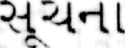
સૂચના
